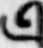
এ
